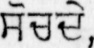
ਸੋਚਦੇ,
